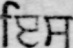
ਇਸ
